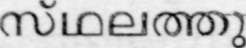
സ്ഥലത്തു
